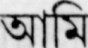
আমি
